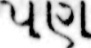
પણ
